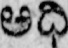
ಅಧಿ
